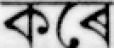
কৰে
